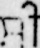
ਸੀ
